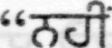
''ਨਹੀਂ
